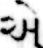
એ
